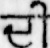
ਦੀ
